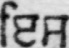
ਇਸ
